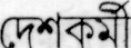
দেশকৰ্মী
